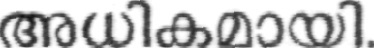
അധികമായി.
